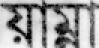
য়াম্না
